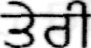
ਤੇਰੀ
